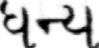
ધન્ય
